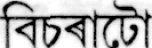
বিচৰাটো
